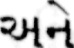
અને
